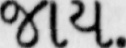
જાય.
